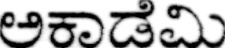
ಅಕಾಡೆಮಿ
